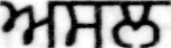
ਅਸਲ
